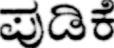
ಪುಡಿಕೆ
